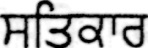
ਸਤਿਕਾਰ
